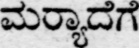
ಮರ್ಯಾದೆಗೆ
